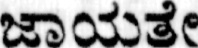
ಜಾಯತೇ
